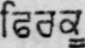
ਫਿਰਕੂ
